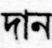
দান
